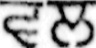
ਵਲ
